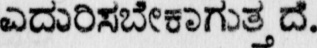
ಎದುರಿಸಬೇಕಾಗುತ್ತದೆ.
